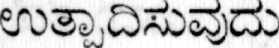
ಉತ್ಪಾದಿಸುವುದು
